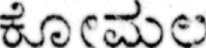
ಕೋಮಲ
